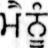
ਮੈਨੂੰ
